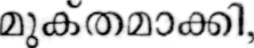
മുക്തമാക്കി,
